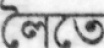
লৈতে
